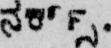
ನರ್ಕ್ಸ್.
